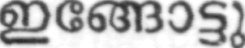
ഇങ്ങോട്ടു
